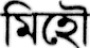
মিহৌ
